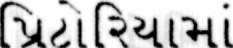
પ્રિટોરિયામાં
